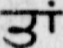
ਤਾਂ
